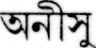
অনীসু
